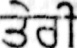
ਤੇਰੀ
